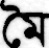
মৈ
